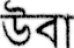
উবা
